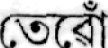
তেৱোঁ
